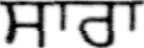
ਸਾਰਾ
